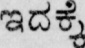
ಇದಕ್ಕೆ
